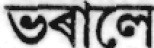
ভৰালে
